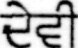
ਦੇਵੀ
